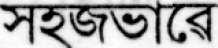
সহজভাৱে
